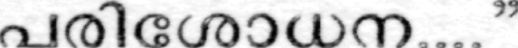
പരിശോധന....''
